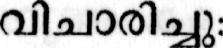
വിചാരിച്ചു:
